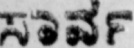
ಸಾರ್ವ
